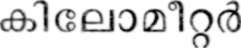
കിലോമീറ്റര്‍
